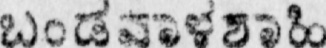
ಬಂಡವಾಳಶಾಹಿ
